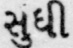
સુધી
